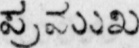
ಪ್ರಮುಖ
